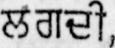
ਲਗਦੀ,
